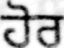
ਹੋਰ
